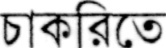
চাকরিতে
